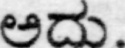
ಅದು.
